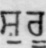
ਸ਼ੁਰੂ
